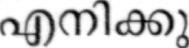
എനിക്കു
